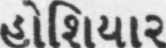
હોશિયાર
